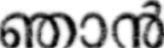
ഞാന്‍
